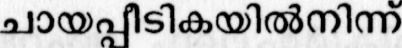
ചായപ്പീടികയില്‍നിന്ന്
